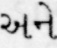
અને
